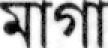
মাগা
